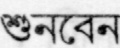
শুনবেন
